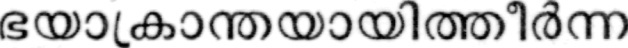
ഭയാക്രാന്തയായിത്തീര്‍ന്ന
